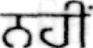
ਨਹੀਂ
